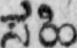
ಸಹಿ
